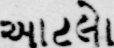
આટલો
